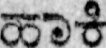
ಹಾಕಿ
